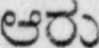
ಆರು
